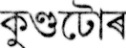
কুণ্ডটোৰ
